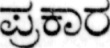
ಪ್ರಕಾರ
